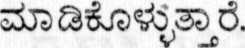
ಮಾಡಿಕೊಳ್ಳುತ್ತಾರೆ.
